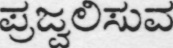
ಪ್ರಜ್ವಲಿಸುವ
